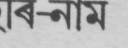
হৰি-নাম
